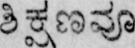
ಶಿಕ್ಷಣವೂ
